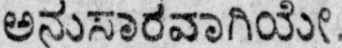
ಅನುಸಾರವಾಗಿಯೇ.
